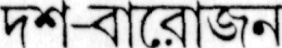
দশ-বারোজন
